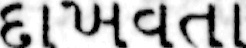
દાખવતા
